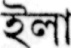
ইলা
